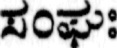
ಸಂಘಃ
